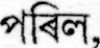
পৰিল,
